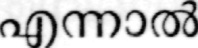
എന്നാല്‍
